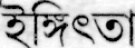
ইঙ্গিৎতা
